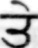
ਤੇ
